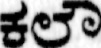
ಕಲೌ
